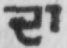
ਦਾ
